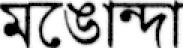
মঙোন্দা
